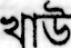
খাউ
